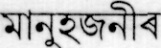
মানুহজনীৰ
